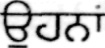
ਉਹਨਾਂ
